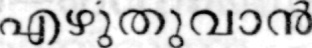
എഴുതുവാന്‍
